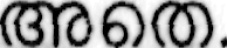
അതെ.
